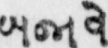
બજાવે
